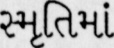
સ્મૃતિમાં
